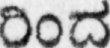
ರಿಂದ
